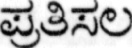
ಪ್ರತಿಸಲ
